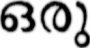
ഒരു
